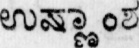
ಉಷ್ಣಾಂಶ
